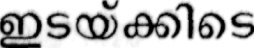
ഇടയ്ക്കിടെ
